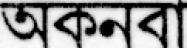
অকনবা
